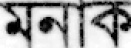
মনাক
